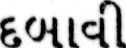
દબાવી
